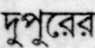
দুপুরের
